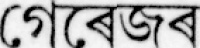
গেৰেজৰ
